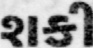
શકી
